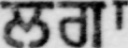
ਲਗਾ
